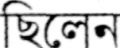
ছিলেন
